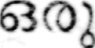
ഒരു
